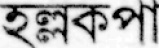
হল্লকপা
